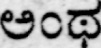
ಅ೦ಥ
